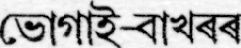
ভোগাই-বাখৰৰ
